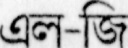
এল-জি
